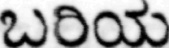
ಬರಿಯ
